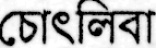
চোৎলিবা
